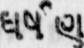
ઘર્ષણ
